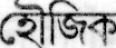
হৌজিক
